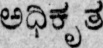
ಅಧಿಕೃತ
